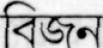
বিজন
